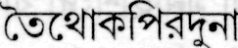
তৈথোকপিরদুনা
